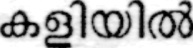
കളിയില്‍
